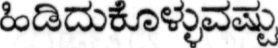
ಹಿಡಿದುಕೊಳ್ಳವಷ್ಟು
